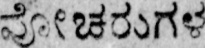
ವೋಚರುಗಳ
